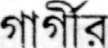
গার্গীর
